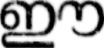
ഈ
